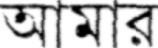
আমার
